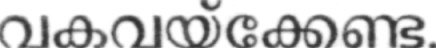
വകവയ്ക്കേണ്ട.
